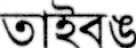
তাইবঙ
